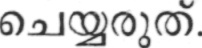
ചെയ്യരുത്.
